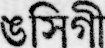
ঙসিগী
